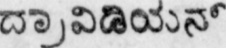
ದ್ರಾವಿಡಿಯನ್
